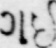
ગઈ
